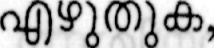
എഴുതുക,
